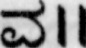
ವ||
